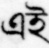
এই
